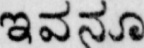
ಇವನೂ
